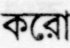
করো
